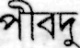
পীবদু
